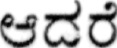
ಆದರೆ
